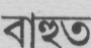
বাহুত
